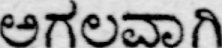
ಅಗಲವಾಗಿ
